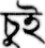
চুই
